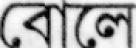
বোলে
